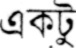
একটু
